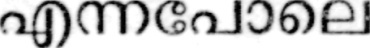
എന്നപോലെ
